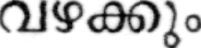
വഴക്കും
